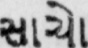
સાચો
